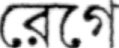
রেগে
